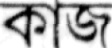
কাজ
